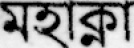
মহাক্না
